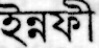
ইন্নফী
